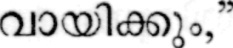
വായിക്കും,"
